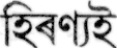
হিৰণ্যই
